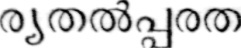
ര്യതല്‍പ്പരത
